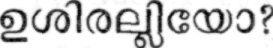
ഉശിരല്ലിയോ?
